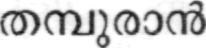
തമ്പുരാന്‍
